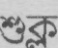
শুক্ল
